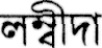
লম্বীদা
